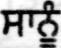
ਸਾਨੂੰ
